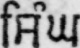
ਸਿੰਘ
